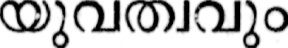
യുവത്വവും
